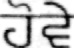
ਹੋਵੇ
